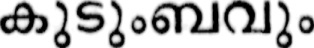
കുടുംബവും
